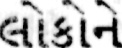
લોકોને
